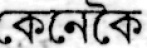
কেনেকৈ
